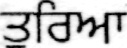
ਤੁਰਿਆ
